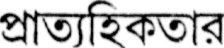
প্রাত্যহিকতার
